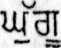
ਘੁੱਗੂ
